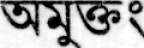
অমুক্তং
